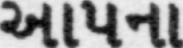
આપના
